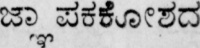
ಜ್ಞಾಪಕಕೋಶದ
